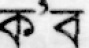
ক'ব
